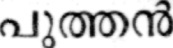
പുത്തന്‍
